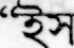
“ইস
